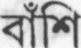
বাঁশি
